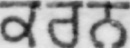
ਕਰਨ
